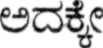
ಅದಕ್ಕೇ
